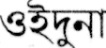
ওইদুনা
